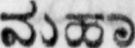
ಮಹಾ
